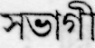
সভাগী
